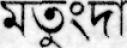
মতুংদা
